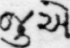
જુએ
